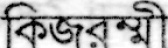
কিজরম্মী
